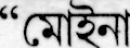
“মোইনা
